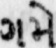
ગમે
